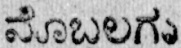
ಮೊಬಲಗು
